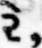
રે,
